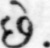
છે.
